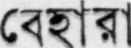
বেহারা
